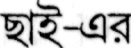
ছাই-এর
